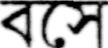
বসে
